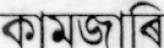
কামজাৰি
